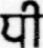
ਧੀ
